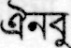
ঐনবু
